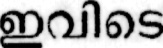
ഇവിടെ
